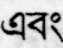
এবং
